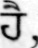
ਹੈ,
